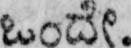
ಒಂದೇ.
